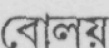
বোলয়
